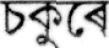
চকুৰে
